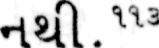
નથી.૧૧૩
